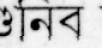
শুনিব
